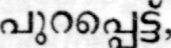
പുറപ്പെട്ട്,
